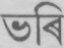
ভৰি
